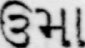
ઉમા
